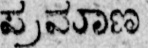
ಪ್ರಮಾಣ
